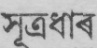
সূত্রধাৰ
